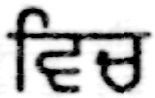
ਵਿਚ
